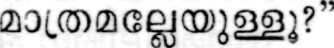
മാത്രമല്ലേയുള്ളൂ?”
